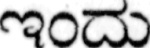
ಇಂದು
